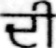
ਦੀ
